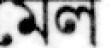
মেল
